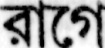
রাগে
